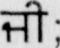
ਜੀ;
